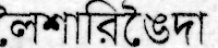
লৈশারিঙৈদা
